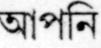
আপনি
